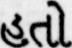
હતો
